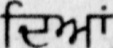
ਦਿਆਂ
